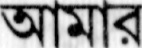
আমার
